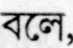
বলে,
